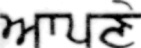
ਆਪਣੇ
